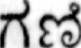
ಗಣಿ
